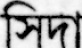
সিদা
